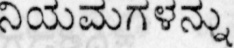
ನಿಯಮಗಳನ್ನು
